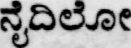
ನೈದಿಲೋ
